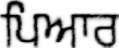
ਪਿਆਰ
